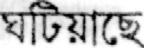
ঘটিয়াছে
